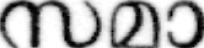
സമാ
